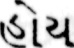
હોય
